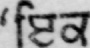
'ਇਕ
